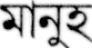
মানুহ
